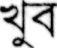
খুব
